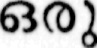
ഒരു
